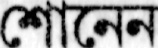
শোনেন
